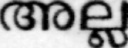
അല്ല
